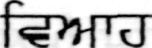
ਵਿਆਹ
